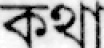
কথা
